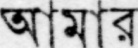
আমার
